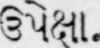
ઉપેક્ષા.
